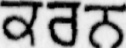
ਕਰਨ
